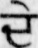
ਦੇ
